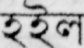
হইল
